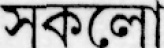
সকলো
